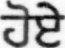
ਹੋਏ
